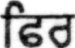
ਫਿਰ
